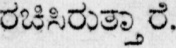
ರಚಿಸಿರುತ್ತಾರೆ.
